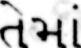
તેમાં
